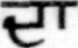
ਦਾ
